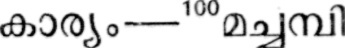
കാര്യം-100മച്ചമ്പി
